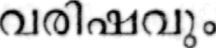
വരിഷവും
